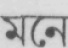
মনে
